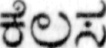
ಕೆಲಸ
